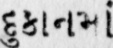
દુકાનમાં
